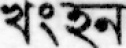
খংহন
